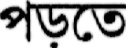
পড়তে
